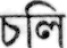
চলি
